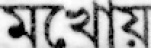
মখোয়
